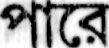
পারে
